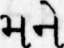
મને
